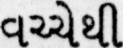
વચ્ચેથી
